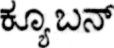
ಕ್ಯೂಬನ್
